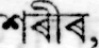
শৰীৰ,
